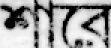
শারে
